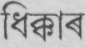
ধিক্কাৰ
